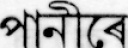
পানীৰে
